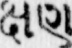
ક્ષણ
